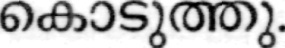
കൊടുത്തു.
